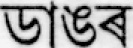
ডাঙৰ
